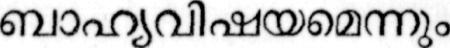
ബാഹ്യവിഷയമെന്നും
